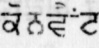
ਕੋਨਵੈਂਟ
